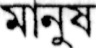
মানুষ
